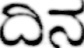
ದಿನ
